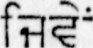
ਜਿਵੇਂ
